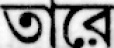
তারে
